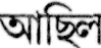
আছিল
